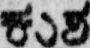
ಕುಶ
